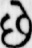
છે
